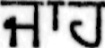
ਜਾਹ
